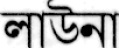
লাউনা
